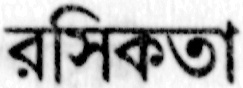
রসিকতা
